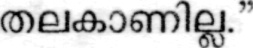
തലകാണില്ല.”
